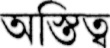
অস্তিত্ব।
